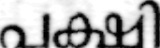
പക്ഷി
